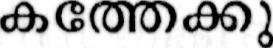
കത്തേക്കു
